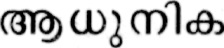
ആധുനിക
